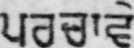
ਪਰਚਾਵੇ
